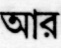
আর
